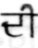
ਦੀ
